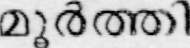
മൂര്‍ത്തി
